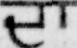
ਦਾ
